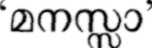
‘മനസ്സാ'
